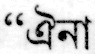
“ঐনা
